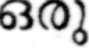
ഒരു
